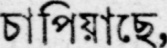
চাপিয়াছে,
